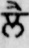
ਲੈ
